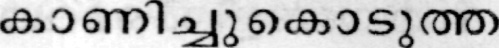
കാണിച്ചുകൊടുത്ത
